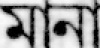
মানা
